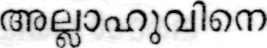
അല്ലാഹുവിനെ
